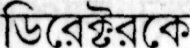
ডিরেক্টরকে
